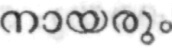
നായരും
